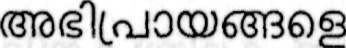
അഭിപ്രായങ്ങളെ
